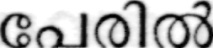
പേരില്‍
